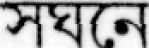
সঘনে
